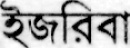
ইজরিবা
